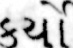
કર્યો
